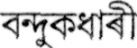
বন্দুকধাৰী
